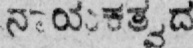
ನಾಯಕತ್ವದ
